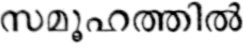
സമൂഹത്തില്‍
